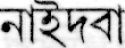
নাইদবা
